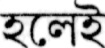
হলেই
